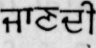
ਜਾਣਦੀ
